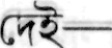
দেই-
